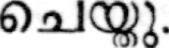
ചെയ്തു.
